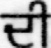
ਦੀ
